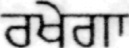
ਰਖੇਗਾ
